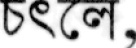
চৎলে,
